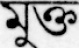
মুক্ত
